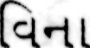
વિના
